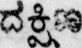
ದಕ್ಷಿಣ
